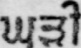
ਘੜੀ
